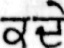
ਕਦੇ
